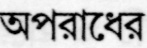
অপরাধের
